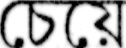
চেয়ে
